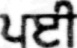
ਪਈ
